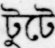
টুটে
